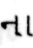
ના
